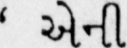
'એની
